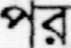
পর
